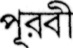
পূরবী
